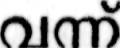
വന്ന്
